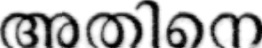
അതിനെ
